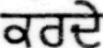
ਕਰਦੇ
